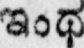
ಇಂಥ
